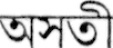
অসতী
